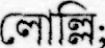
লোল্লি,
